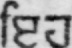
ਇਹ
